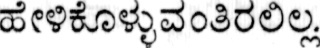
ಹೇಳಿಕೊಳ್ಳುವಂತಿರಲಿಲ್ಲ.
